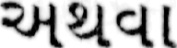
અથવા
